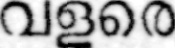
വളരെ
